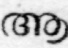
ആ
